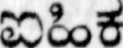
ಐಹಿಕ
